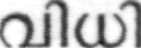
വിധി
